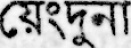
য়েংদুনা
